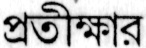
প্রতীক্ষার
